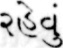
રહેવું
